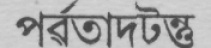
পৰ্ৱতাদটন্তু
